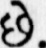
છે.
